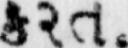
કરત.
